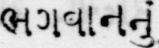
ભગવાનનું
